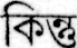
কিন্তু
